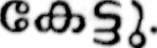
കേട്ടു.
